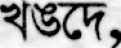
খঙদে,
